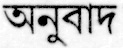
অনুবাদল
